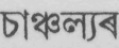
চাঞ্চল্যৰ
